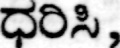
ಧರಿಸಿ,
